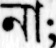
না;
